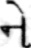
ને
